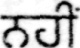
ਨਹੀਂ
